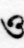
ও
